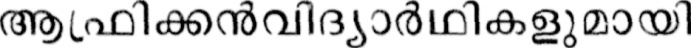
ആഫ്രിക്കന്‍വിദ്യാര്‍ഥികളുമായി
